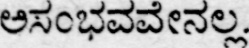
ಅಸಂಭವವೇನಲ್ಲ.
